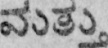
ಮತ್ತು
